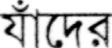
যাঁদের
